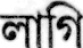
লাগি
